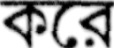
করে
